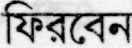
ফিরবেন
